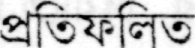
প্রতিফলিত
